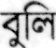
বুলি
